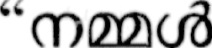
“നമ്മള്‍
